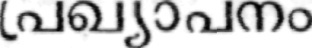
പ്രഖ്യാപനം
